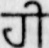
ਹੀ
